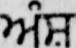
ਅੰਸ਼
